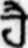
ਹੈ
